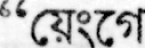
“য়েংগে
